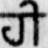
ਹੀ
